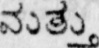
ಮತ್ತು
